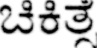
ಚಿಕಿತ್ಸೆ
